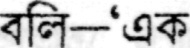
বলি—‘এক
